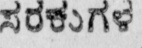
ಸರಕುಗಳ
